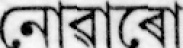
নোৱাৰো
